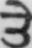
ਤੇ
